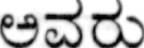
ಅವರು
